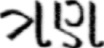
ત્રણ
